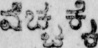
ವೆಚ್ಚಕ್ಕೆ
